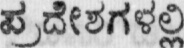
ಪ್ರದೇಶಗಳಲ್ಲಿ
